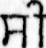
ਸੀ
